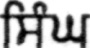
ਸਿੰਘ
